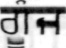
ਗੂੰਜ
